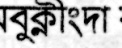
মবুক্নীংদা
